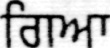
ਗਿਆ
